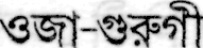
ওজা-গুরুগী
